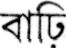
বাঢ়ি
